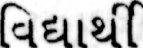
વિધાર્થી
